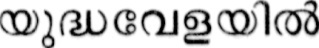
യുദ്ധവേളയില്‍
